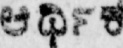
ಆರ್ಥಿಕ
